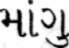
માંગુ
